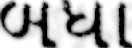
બધા
